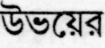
উভয়ের
